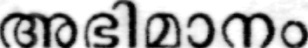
അഭിമാനം
